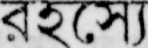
রহস্যে
